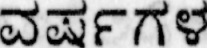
ವರ್ಷಗಳ
